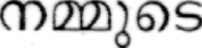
നമ്മുടെ
